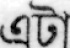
এটা
